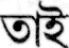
তাই
